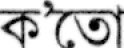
ক'তো
